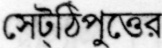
সেট্ঠিপুত্তের
